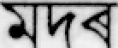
মদৰ
